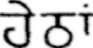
ਹੇਠਾਂ
